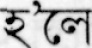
হ'লে
